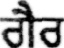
ਗੈਰ
